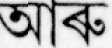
আৰু
